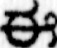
ಈ
